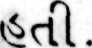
હતી.
